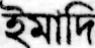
ইমাদি
